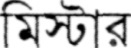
মিস্টার
